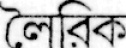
লৈরিক
